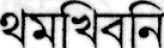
থমখিবনি
